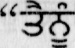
''ਤੈਨੂੰ
